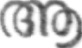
ആ
